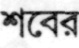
শবের
